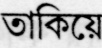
তাকিয়ে
